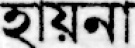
হায়না
